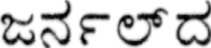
ಜರ್ನಲ್ದ
